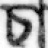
চা
